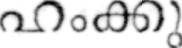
ഹംക്കു
